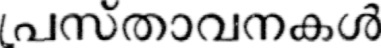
പ്രസ്താവനകള്‍
